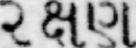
રક્ષણ
